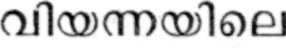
വിയന്നയിലെ
